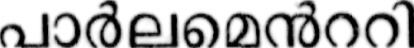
പാര്‍ലമെന്ററി
